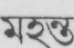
মহন্ত
